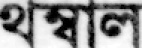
থম্বাল
